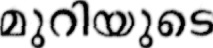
മുറിയുടെ
